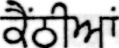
ਕੈਂਠੀਆਂ
